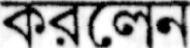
করলেন
